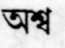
অশ্ব
